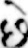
છે
